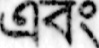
এবং
